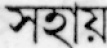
সহায়
